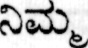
ನಿಮ್ಮ
